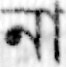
না
